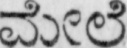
ಮೇಲೆ
